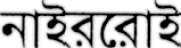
নাইররোই
